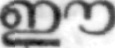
ഈ
